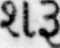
શરૂ
